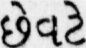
છેવટે
